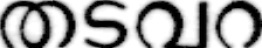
തടവറ
